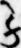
કે
